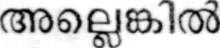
അല്ലെങ്കില്‍
